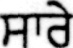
ਸਾਰੇ
